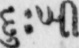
દુઃખી
